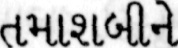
તમાશબીને
